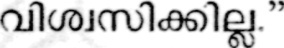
വിശ്വസിക്കില്ല.”
